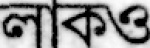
লাকও
